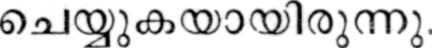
ചെയ്യുകയായിരുന്നു.
